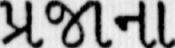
પ્રજાના
